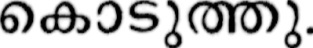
കൊടുത്തു.
